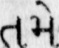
તમે
